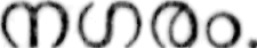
നഗരം.
